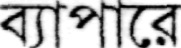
ব্যাপারে
